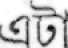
এটা
